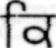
ਕਿ
